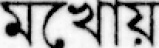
মখোয়
